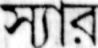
স্যার
